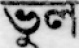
ভুল
